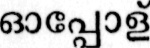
ഓപ്പോള്
